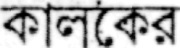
কালকের
